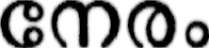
നേരം
